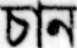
চান
